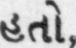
હતો,
